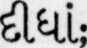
દીધાં
